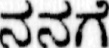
ನನಗೆ
